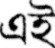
এই
